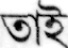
তাই
